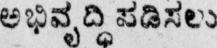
ಅಭಿವೃದ್ಧಿಪಡಿಸಲು
